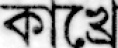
কাখ্রে
